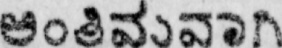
ಅಂತಿಮವಾಗಿ
